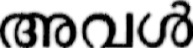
അവള്‍
